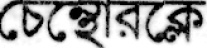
চেন্থোরক্লে
